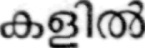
കളില്‍
